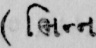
(ભિન્ન
